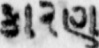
કારણ
